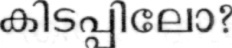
കിടപ്പിലോ?
